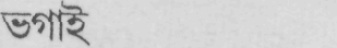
ভগাই
